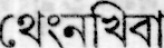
থেংনখিবা
